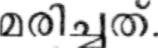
മരിച്ചത്.
